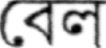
বেল
